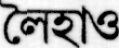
লৈহাও
